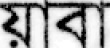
য়াবা
